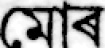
মোৰ
